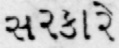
સરકારે
